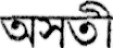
অসতী
